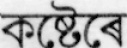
কষ্টেৰে
